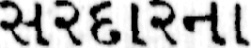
સરદારના
